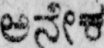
ಅನೇಕ
